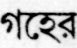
গহের
